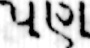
પણ
